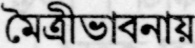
মৈত্রীভাবনায়
